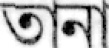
তানা
